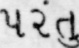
પરંતુ
